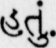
હતું.
